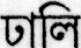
ঢালি
